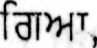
ਗਿਆ,
